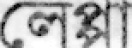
লেপ্পা
